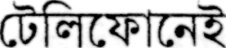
টেলিফোনেই
